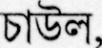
চাউল,
